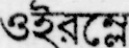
ওইরম্লে
